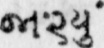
જાણ્યું
